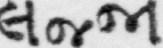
લજ્જા
